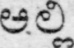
ಅಲ್ಲಿ
